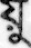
য়ু
